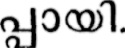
പ്പായി.
